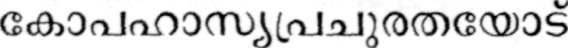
കോപഹാസ്യപ്രചുരതയോട്
